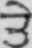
ਤੇ
